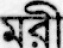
মরী
